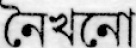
নৈখনো
